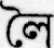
লৈ
